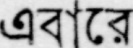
এবারে
